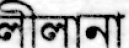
লীলানা
